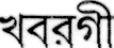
খবরগী
